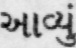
આવ્યું
